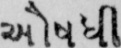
ઔષધી
